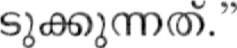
ടുക്കുന്നത്.”
